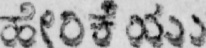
ಹೇರಿಕೆಯು
